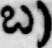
ಬ)
